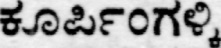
ಕೂರ್ಪಿಂಗಳ್ಕಿ
